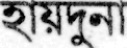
হায়দুনা
